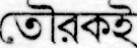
তৌরকই
